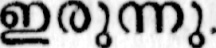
ഇരുന്നു.
